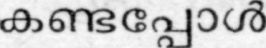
കണ്ടപ്പോള്‍
